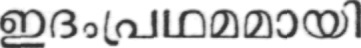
ഇദംപ്രഥമമായി
